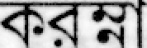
করম্না
